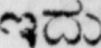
ಇದು
